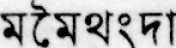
মমৈথংদা
